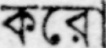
করো
